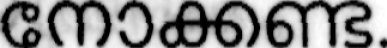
നോക്കണ്ട.
